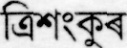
ত্রিশংকুৰ
